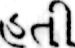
હતી
